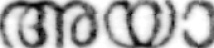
അയാ
